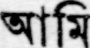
আমি
